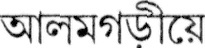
আলমগড়ীয়ে
